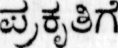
ಪ್ರಕೃತಿಗೆ
